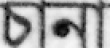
চানা
